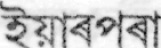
ইয়াৰপৰা
